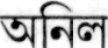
অনিল
